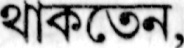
থাকতেন,
